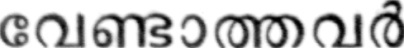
വേണ്ടാത്തവര്‍
